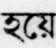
হয়ে
